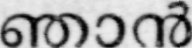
ഞാന്‍
